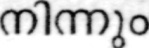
നിന്നും
